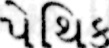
પેથિક
